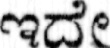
ಇದೇ
